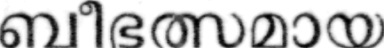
ബീഭത്സമായ
